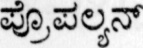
ಪ್ರೊಪಲ್ಯನ್
